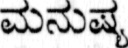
ಮನುಷ್ಯ
